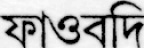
ফাওবদি
